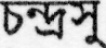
চন্দ্রসু
